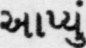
આપ્યું
